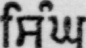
ਸਿੰਘ
